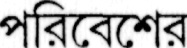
পরিবেশের
